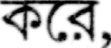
করে,
